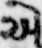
એ
